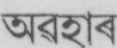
অৱহাৰ
